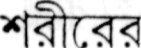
শরীরের
